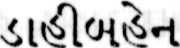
ડાહીબહેન
